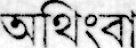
অথিংবা
